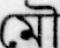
মৌ
